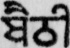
ਬੈਠੀ
